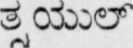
ತ್ಸಯುಲ್
